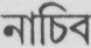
নাচিব
